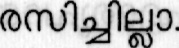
രസിച്ചില്ലാ.
